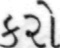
કરો
